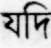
যদি
